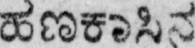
ಹಣಕಾಸಿನ
